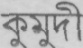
কুমুদী
